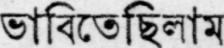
ভাবিতেছিলাম
